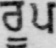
ਰੂਪ
